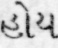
હોય
